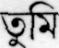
তুমি
